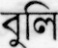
বুলি
